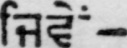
ਜਿਵੇਂ-
